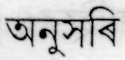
অনুসৰি
